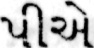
પીએ
